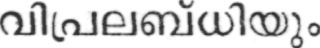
വിപ്രലബ്ധിയും
